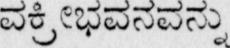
ವಕ್ರೀಭವನವನ್ನು
